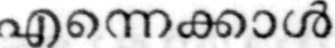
എന്നെക്കാള്‍
